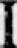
I
